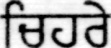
ਚਿਹਰੇ
